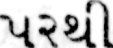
પરથી
